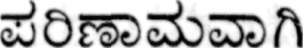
ಪರಿಣಾಮವಾಗಿ
